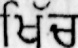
ਖਿੱਚ
